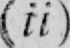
(ii)
